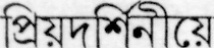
প্রিয়দৰ্শিনীয়ে
